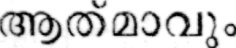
ആത്മാവും
